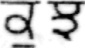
ਕੁਝ
